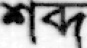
শব্দ
